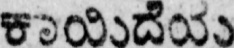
ಕಾಯಿದೆಯ
